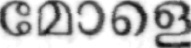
മോളെ
